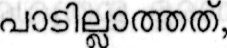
പാടില്ലാത്തത്,
